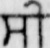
ਸੀ
